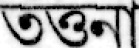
তত্তনা
